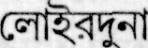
লোইরদুনা
